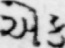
એક
